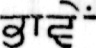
ਭਾਵੇਂ
